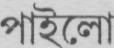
পাইলো
